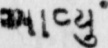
આવ્યું
